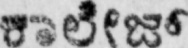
ಕಾಲೇಜ್
